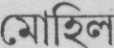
মোহিল
